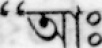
"আঃ
